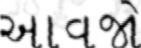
આવજો
